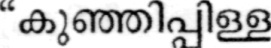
“കുഞ്ഞിപ്പിള്ള
